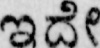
ಇದೇ
